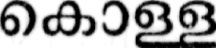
കൊള്ള
